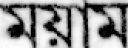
ময়াম
